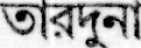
তারদুনা
